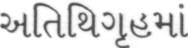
અતિથિગૃહમાં
